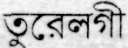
তুরেলগী
